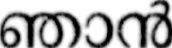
ഞാന്‍
